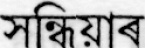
সন্ধিয়াৰ
